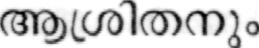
ആശ്രിതനും
